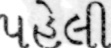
પહેલી
